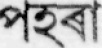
পহৰা
